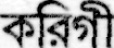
করিগী
